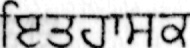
ਇਤਹਾਸਕ
